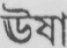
ঊষা
